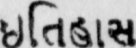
ઇતિહાસ
